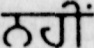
ਨਹੀਂ
